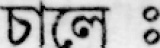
চালেঃ
